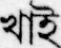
খাই
